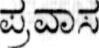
ಪ್ರವಾಸ
